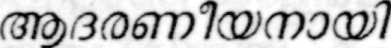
ആദരണീയനായി
